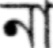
না
